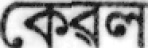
কেৱল
